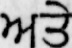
ਅਤੇ
